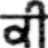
ਕੀ
